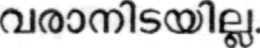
വരാനിടയില്ല.
